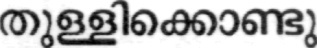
തുള്ളിക്കൊണ്ടു
